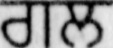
ਗਲ
